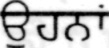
ਉਹਨਾਂ
